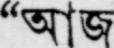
‘‘আজ
